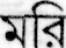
মরি
